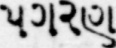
પગરણ
